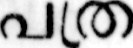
പത്ര
